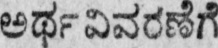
ಅರ್ಥವಿವರಣೆಗೆ
